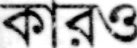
কারও
